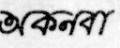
অকনবা
